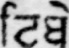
ਟਿਬੇ
